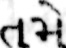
તમે
